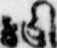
કહી
